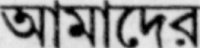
আমাদের
